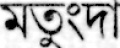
মতুংদা
